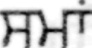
ਸਮਾਂ
